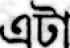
এটা
